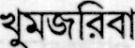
খুমজরিবা
